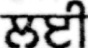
ਲਈ
